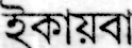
ইকায়বা
